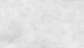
જ.
